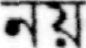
নয়
